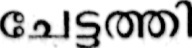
ചേട്ടത്തി
